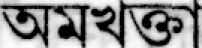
অমখক্তা
